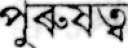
পুৰুষত্ব
